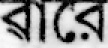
ৱারে
